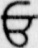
ਓ
